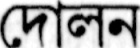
দোলন
